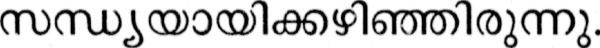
സന്ധ്യയായിക്കഴിഞ്ഞിരുന്നു.
